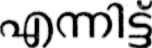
എന്നിട്ട്
